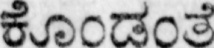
ಕೊಂಡಂತೆ
